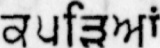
ਕਪੜਿਆਂ
